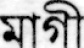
মাগী
